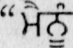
''ਮੈਨੂੰ
